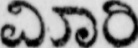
ಮೀರಿ
